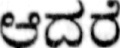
ಆದರೆ
